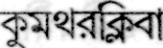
কুমথরক্লিবা
